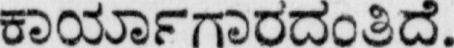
ಕಾರ್ಯಾಗಾರದಂತಿದೆ.
